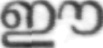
ഈ
